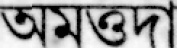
অমত্তদা
